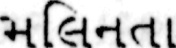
મલિનતા
